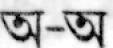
অ-অ
